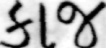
કાજ
